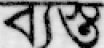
ব্যস্ত
